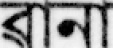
ৱানা
